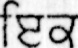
ਇਕ
